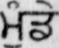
ਮੁੰਡੇ
